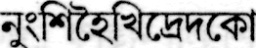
নুংশিহৈখিদ্রেদকো
